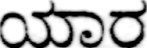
ಯಾರ
